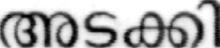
അടക്കി
